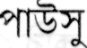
পাউসু
